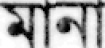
মানা
